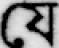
যে
